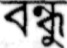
বন্ধু
